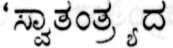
'ಸ್ವಾತಂತ್ರ್ಯದ
